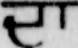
ਦਾ
